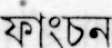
ফাংচন
